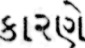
કારણે
